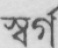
স্বৰ্গ
